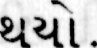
થયો.
